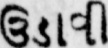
ઉડાવી
